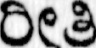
ರೀತಿ
